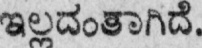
ಇಲ್ಲದಂತಾಗಿದೆ.
